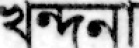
খন্দনা
